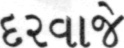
દરવાજે
